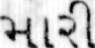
મારી
